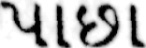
પાછા
